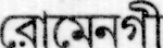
রোমেনগী
